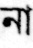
না
